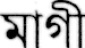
মাগী
